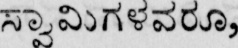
ಸ್ವಾಮಿಗಳವರೂ,
